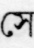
সে
